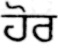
ਹੋਰ
